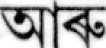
আৰু
